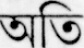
অতি
